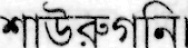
শাউরুগনি।
